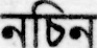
নচিন
